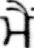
ਮੈਂ
